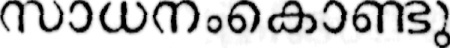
സാധനംകൊണ്ടു
